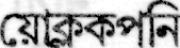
য়োক্লকপনি
